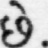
છે.
